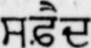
ਸਫ਼ੈਦ
